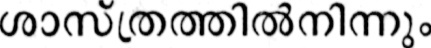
ശാസ്ത്രത്തില്‍നിന്നും
